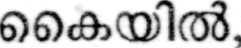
കൈയില്‍,
